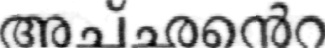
അച്ഛന്റെ
